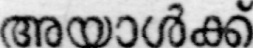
അയാള്‍ക്ക്
